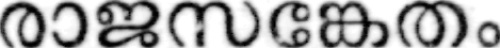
രാജസങ്കേതം
